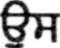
ਉਸ
